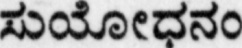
ಸುರ್ಯೋಧನಂ
